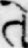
તે
